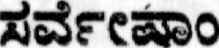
ಸರ್ವೇಷಾಂ
